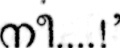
നീ......!’
